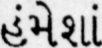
હંમેશાં
